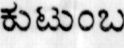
ಕುಟುಂಬ
